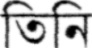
তিনি
